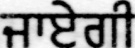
ਜਾਏਗੀ
